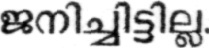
ജനിച്ചിട്ടില്ല.
